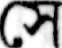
সে
